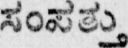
ಸಂಪತ್ತು
